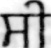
ਸੀ
